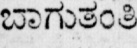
ಬಾಗುತಂತಿ
